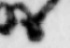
જ
